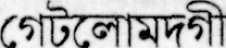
গেটলোমদগী
